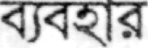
ব্যবহার
